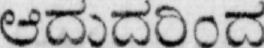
ಆದುದರಿಂದ
